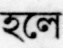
হলে
